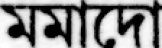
মমাদো
